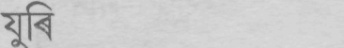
যুৰি
